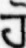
ਹੋ
